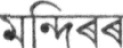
মন্দিৰৰ
